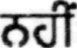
ਨਹੀਂ
